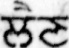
ਲੈਣ
